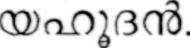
യഹൂദന്‍.
